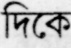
দিকে
